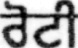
ਰੋਟੀ
